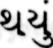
થયું
